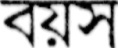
বয়স
